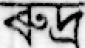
ৰুদ্ৰ
